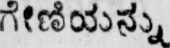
ಗೇಣಿಯನ್ನು
